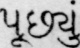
પૂછ્યું
